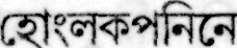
হোংলকপনিনে
